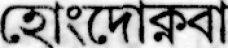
হোংদোক্নবা
